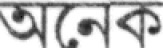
অনেক
